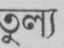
তুল্য
